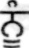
ਨੂੰ
